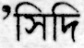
’সিদি
